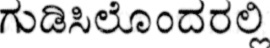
ಗುಡಿಸಿಲೊಂದರಲ್ಲಿ
